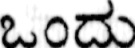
ಒಂದು
